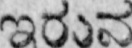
ಇರುವ
